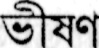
ভীষণ
